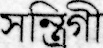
সন্ত্রিগী
